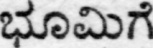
ಭೂಮಿಗೆ
